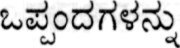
ಒಪ್ಪಂದಗಳನ್ನು
